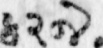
કરજે.
